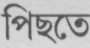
পিছতে
